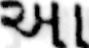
આ
